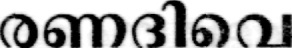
രണദിവെ
